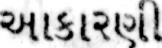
આકારણી
